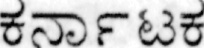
ಕರ್ನಾಟಕ
